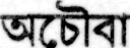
অচৌবা
